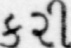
કરી
